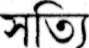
সত্যি
